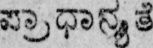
ಪ್ರಾಧಾನ್ಯತೆ
